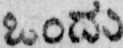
ಒಂದು
